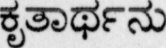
ಕೃತಾರ್ಥನು
